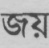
জয়
